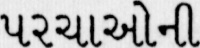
પરચાઓની
